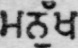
ਮਨੁੱਖ
